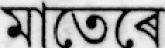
মাতেৰে
